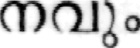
നവും
